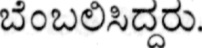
ಬೆಂಬಲಿಸಿದ್ದರು.
